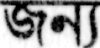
জন্য
